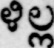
ಳಿಲ್ಲ
